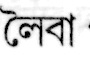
লৈবা
